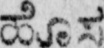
ಹೊಸ
